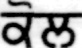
ਕੋਲ
